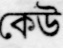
কেউ
